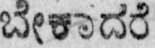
ಬೇಕಾದರೆ
